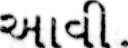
આવી.
